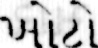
ખોટો
